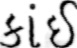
કાંઈ
